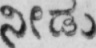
ನೀಡು
